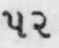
પર
